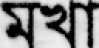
মখা
